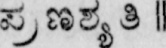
ಪ್ರಣಶ್ಯತಿ
